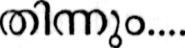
തിന്നും....
